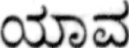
ಯಾವ
